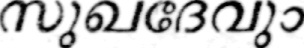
സുഖദേവുാ
